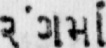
રંગમાં
